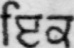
ਇਕ
